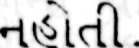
નહોતી.
